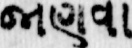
જાણવા
